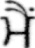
ਮੈਂ
